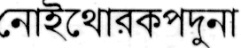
নোইথোরকপদুনা
